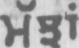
ਮੱਝਾਂ
